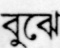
বুঝে
